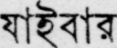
যাইবার
